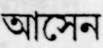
আসেন
